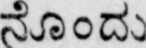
ನೊಂದು
